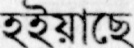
হইয়াছে
